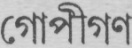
গোপীগণ
